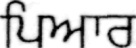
ਪਿਆਰ
